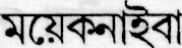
ময়েকনাইবা
